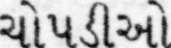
ચોપડીઓ
